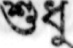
শুধু
